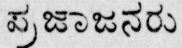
ಪ್ರಜಾಜನರು
